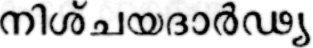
നിശ്ചയദാര്‍ഢ്യ
